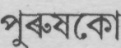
পুৰুষকো
